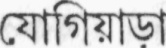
যোগিয়াড়া
